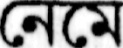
নেমে
